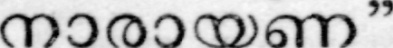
നാരായണ"
